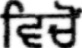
ਵਿਚੋਂ
